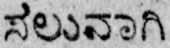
ಸಲುವಾಗಿ
